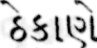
ઠેકાણે
